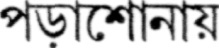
পড়াশোনায়
